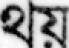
থয়
